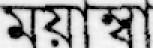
ময়াম্বা
